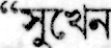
"সুখেন
